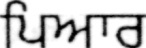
ਪਿਆਰ
